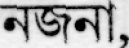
নজনা,
